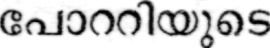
പോററിയുടെ
